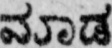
ಮಾಡ
